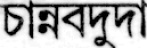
চান্নবদুদা
